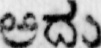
ಅದು
